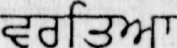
ਵਰਤਿਆ
